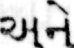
અને
